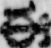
ಈ
